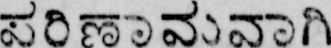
ಪರಿಣಾಮವಾಗಿ
